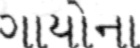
ગાયોના
